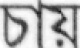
চায়
